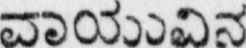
ವಾಯುವಿನ
